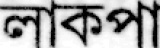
লাকপা
